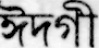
ঈদগী
